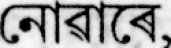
নোৱাৰে,
